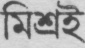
মিশ্ৰই
